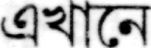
এখানে
